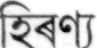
হিৰণ্য
